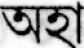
অহা
